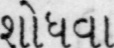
શોધવા
